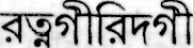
রত্নগীরিদগী
